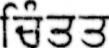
ਚਿੰਤਤ
